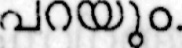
പറയും.
